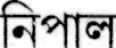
নিপাল
